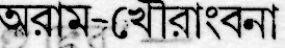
অরাম-খৌরাংবনা
